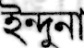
ইন্দুনা
